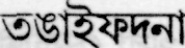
তঙাইফদনা
